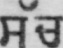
ਸੱਚ
